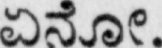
ಏನೋ.
